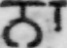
ਨਾ
